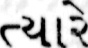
ત્યારે
